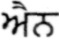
ਐਨ
